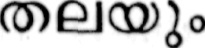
തലയും
